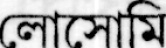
লোসোমি
